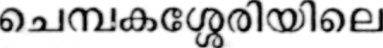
ചെമ്പകശ്ശേരിയിലെ
